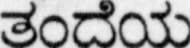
ತಂದೆಯ
